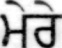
ਮੇਰੇ
